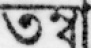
তম্বা
